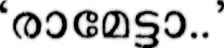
‘രാമേട്ടാ..’
